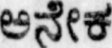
ಅನೇಕ
